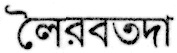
লৈরবতদা
